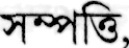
সম্পত্তি,
